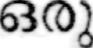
ഒരു
